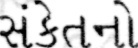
સંકેતનો
